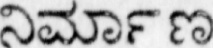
ನಿರ್ಮಾಣ
